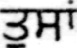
ਤੁਸਾਂ
